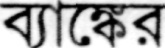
ব্যাঙ্কের
